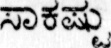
ಸಾಕಷ್ಟು
